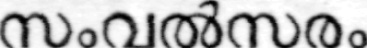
സംവല്‍സരം
